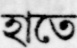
হাতে
